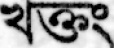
খক্তং
